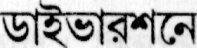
ডাইভারশনে
